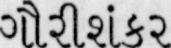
ગૌરીશંકર
